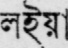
লইয়া
